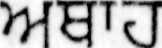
ਅਥਾਹ
